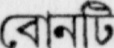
বোনটি
